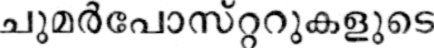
ചുമര്‍പോസ്റ്ററുകളുടെ
